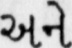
અને
